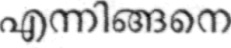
എന്നിങ്ങനെ
